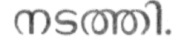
നടത്തി.
